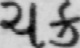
ચક્ર
